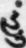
હું
